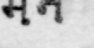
તમને
